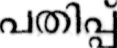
പതിപ്പ്
